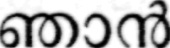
ഞാന്‍
